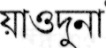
য়াওদুনা
